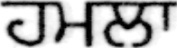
ਹਮਲਾ
